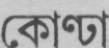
কোণ্ঢা
